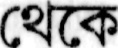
থেকে
